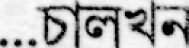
...চালখন
